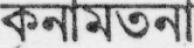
কনামতনা
